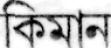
কিমান
